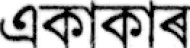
একাকাৰ
